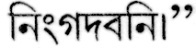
নিংগদবনি।”
